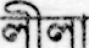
লীলা
